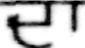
ਦਾ
